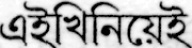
এইখিনিয়েই
